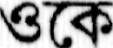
ওকে
